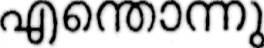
എന്തൊന്നു
